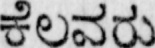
ಕೆಲವರು
